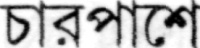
চারপাশে
